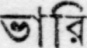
ভারি
